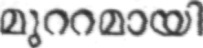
മുററമായി
